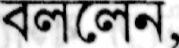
বললেন,
